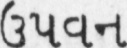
ઉપવન
